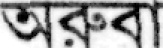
অরুবা
